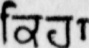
ਕਿਹਾ
